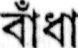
বাঁধা
